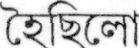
হৈছিলো
